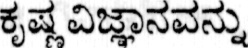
ಕೃಷ್ಣವಿಜ್ಞಾನವನ್ನು
